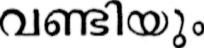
വണ്ടിയും
